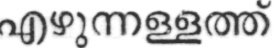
എഴുന്നള്ളത്ത്
